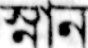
স্নান
